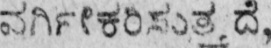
ವರ್ಗೀಕರಿಸುತ್ತದೆ,
